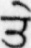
ਤੇ
